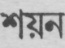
শয়ন
